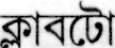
ক্লাবটো
